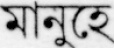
মানুহে
